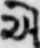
એ
